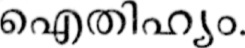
ഐതിഹ്യം.
